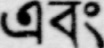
এবং
